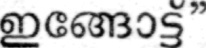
ഇങ്ങോട്ട്”
